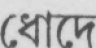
ধোদে
